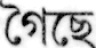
গৈছে
